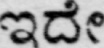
ಇದೇ
